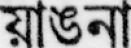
য়াঙনা
